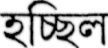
হচ্ছিল
